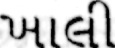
ખાલી
